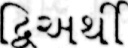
દ્વિઅર્થી
